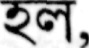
হল,
